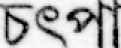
চৎপা
